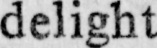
delight
